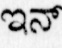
ಇನ್
